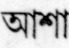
আশা
